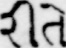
રીતે
